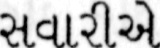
સવારીએ
